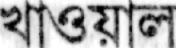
খাওয়াল
